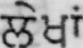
ਲੇਖਾਂ
